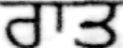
ਰਾਤ
